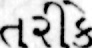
તરીકે
